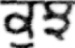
ਕੁਝ
